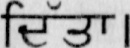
ਦਿੱਤਾ।
